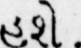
હશે.
